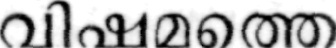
വിഷമത്തെ
